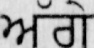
ਅੱਗੇ
